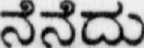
ನೆನೆದು
